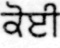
ਕੋਈ
